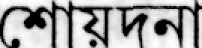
শোয়দনা
